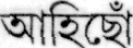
আহিছোঁ
